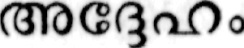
അദ്ദേഹം
